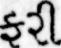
ફરી
